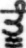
ਤੂੰ
